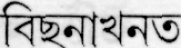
বিছনাখনত
